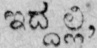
ಇದ್ದಲ್ಲಿ,
